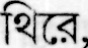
থিরে,
